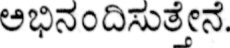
ಅಭಿನಂದಿಸುತ್ತೇನೆ.
